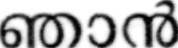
ഞാന്‍
